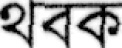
থবক
